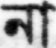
না
